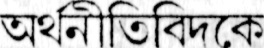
অর্থনীতিবিদকে
